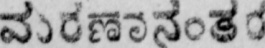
ಮರಣಾನಂತರ
